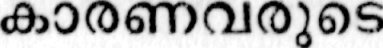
കാരണവരുടെ
